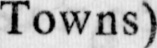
Towns)
